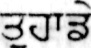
ਤੁਹਾਡੇ
